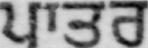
ਪਾਤਰ
